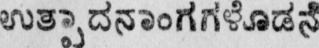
ಉತ್ಪಾದನಾಂಗಗಳೊಡನೆ
